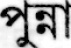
পুন্না
